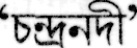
‘চন্দ্রনদী’
